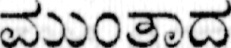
ಮುಂತಾದ
